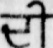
ਦੀ
